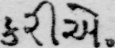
કરીએ.
